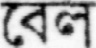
বেল
